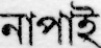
নাপাই
